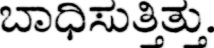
ಬಾಧಿಸುತ್ತಿತ್ತು.
